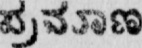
ಪ್ರಮಾಣ
